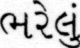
ભરેલું
